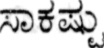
ಸಾಕಷ್ಟು
